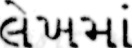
લેખમાં
